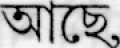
আছে,
